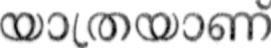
യാത്രയാണ്
